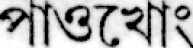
পাওখোং
